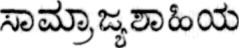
ಸಾಮ್ರಾಜ್ಯಶಾಹಿಯ
